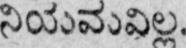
ನಿಯಮವಿಲ್ಲ.
